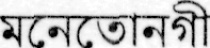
মনেতোনগী
